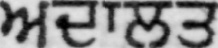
ਅਦਾਲਤ
